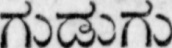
ಗುಡುಗು
